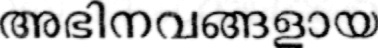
അഭിനവങ്ങളായ
